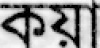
কয়া
